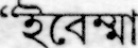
“ইবেম্মা
